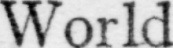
World
